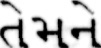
તેમને
